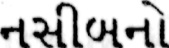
નસીબનો
